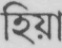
হিয়া
